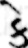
કે
